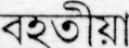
বহতীয়া
